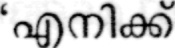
‘എനിക്ക്
